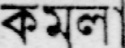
কমলা
